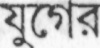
যুগের
